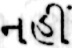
નહીં
